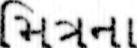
મિત્રના
